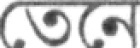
তেনে
